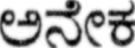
ಅನೇಕ
